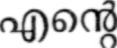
എന്റെ
